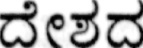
ದೇಶದ
